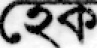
হেক
